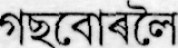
গছবোৰলৈ
